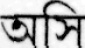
অসি
